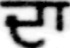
ਦਾ
